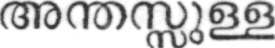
അന്തസ്സുള്ള
